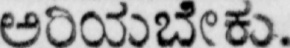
ಅರಿಯಬೇಕು.
